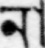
না
